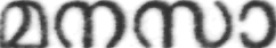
മനസാ
